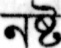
নষ্ট
